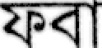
ফবা
